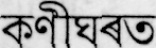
কণীঘৰত
